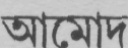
আমোদ
